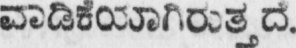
ವಾಡಿಕೆಯಾಗಿರುತ್ತದೆ.
